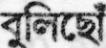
বুলিছোঁ
